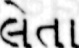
લેતા
